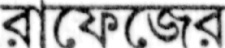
রাফেজের
